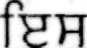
ਇਸ
